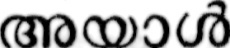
അയാള്‍
